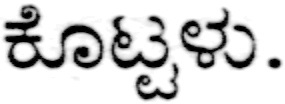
ಕೊಟ್ಟಳು.
